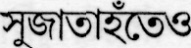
সুজাতাহঁতেও
